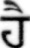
ਹੈ
